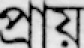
প্রায়
